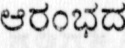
ಆರಂಭದ
